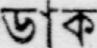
ডাক
